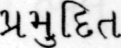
પ્રમુદિત
